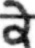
ਕੇ
